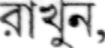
রাখুন,
